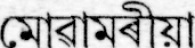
মোৱামৰীয়া
